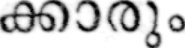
ക്കാരും
